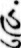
હું
